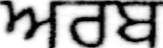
ਅਰਬ
